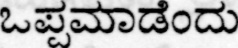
ಒಪ್ಪಮಾಡೆಂದು
